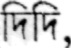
দিদি,
